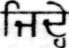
ਜਿਦ੍ਹੇ
